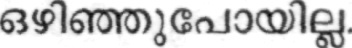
ഒഴിഞ്ഞുപോയില്ല.
